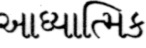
આધ્યાત્મિક
